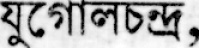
যুগোলচন্দ্র,
